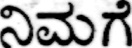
ನಿಮಗೆ
